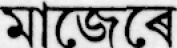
মাজেৰে
